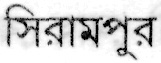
সিরামপুর
